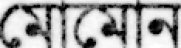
মোমোন
